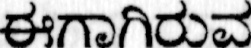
ಈಗಾಗಿರುವ
